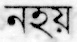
নহয়
